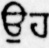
ਉਹ
